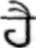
ਹੈ
